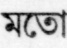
মতো
